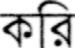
করি
